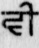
ਵੀ
